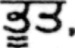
ਭੂਤ,
